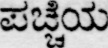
ಪಚ್ಚೆಯ
